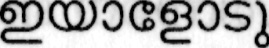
ഇയാളോടു
